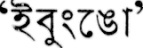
‘ইবুংঙো’
